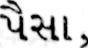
પૈસા,
